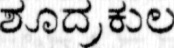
ಶೂದ್ರಕುಲ
